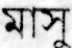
মাসু
